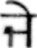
ਜੇ
